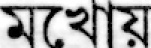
মখোয়
